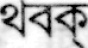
থবক্
